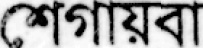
শেগায়বা
